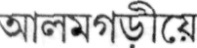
আলমগড়ীয়ে
